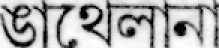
ঙাথেলানা
